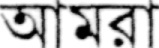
আমরা
